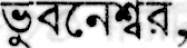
ভুবনেশ্বর,
